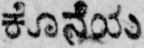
ಕೊನೆಯ
